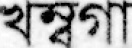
খম্বগা
